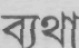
ব্যথা
